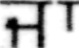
ਜਾ
